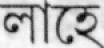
লাহে
